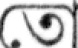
তো
